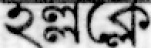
হল্লক্লে
